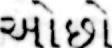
ઓછો
